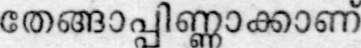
തേങ്ങാപ്പിണ്ണാക്കാണ്
